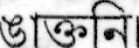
ঙাক্তনি।
